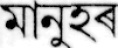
মানুহৰ
